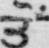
ਤੋਂ
